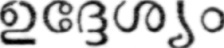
ഉദ്ദേശ്യം
